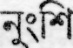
নুংশি
